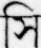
সি
